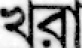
খরা
